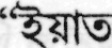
"ইয়াত
